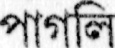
পাগলি
